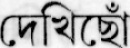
দেখিছোঁ
